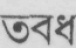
তবধ
